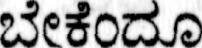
ಬೇಕೆಂದೂ
